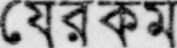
যেরকম
